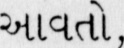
આવતો,
